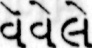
વૅવેલે
